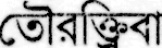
তৌরক্ত্রিবা
